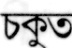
চকুত
